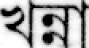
খন্না
